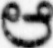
ಆ
